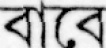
বাবে
